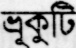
ভ্রূকুটি
